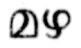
മഴ
